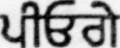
ਪੀਓਗੇ
